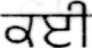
ਕਈ
